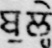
ਬੁਲ੍ਹੇ
